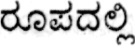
ರೂಪದಲ್ಲಿ
